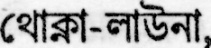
থোক্না-লাউনা,
